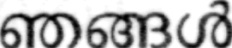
ഞങ്ങള്‍
